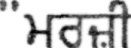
''ਮਰਜ਼ੀ
